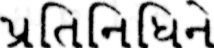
પ્રતિનિધિને
